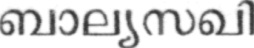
ബാല്യസഖി
